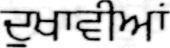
ਦੁਖਾਵੀਆਂ
